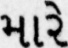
મારે
